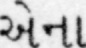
એના
